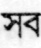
সব
